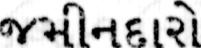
જમીનદારો
